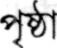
পৃষ্ঠা
